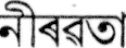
নীৰৱতা
